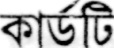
কার্ডটি
